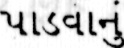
પાડવાનું
